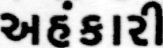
અહંકારી
